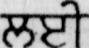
ਲਈ
